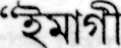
“ইমাগী
